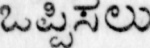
ಒಪ್ಪಿಸಲು
